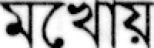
মখোয়
